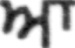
ਆ
